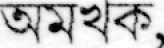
অমখক,
